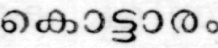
കൊട്ടാരം
